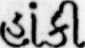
હાંકી
